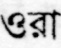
ওরা
